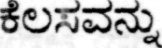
ಕೆಲಸವನ್ನು
